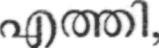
എത്തി,
